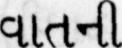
વાતની
